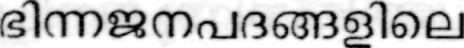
ഭിന്നജനപദങ്ങളിലെ
